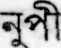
নুপী
